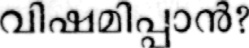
വിഷമിപ്പാന്‍?
